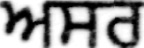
ਅਸਰ
